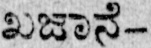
ಖಜಾನೆ-
